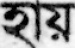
হায়
